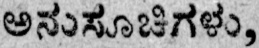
ಅನುಸೂಚಿಗಳು,
